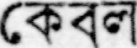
কেবল
